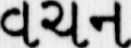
વચન
